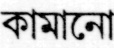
কামানো
